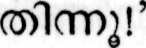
തിന്നൂ!'
